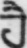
ਹੈ
